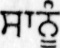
ਸਾਨੂੰ
